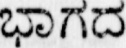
ಭಾಗದ
